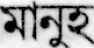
মানুহ
